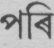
পৰি
